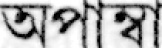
অপাম্বা
